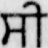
ਸੀ
